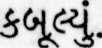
કબૂલ્યું.
